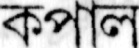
কপাল
